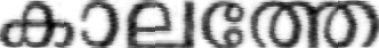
കാലത്തേ
